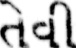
તેવી
